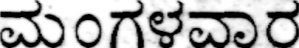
ಮಂಗಳವಾರ
